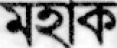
মহাক
